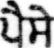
ਪੈਸੇ
